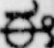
ಈ
